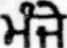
ਮੰਜੇ
